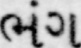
ભંગ
